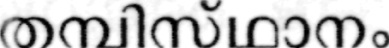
തമ്പിസ്ഥാനം
